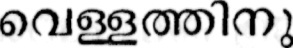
വെള്ളത്തിനു
